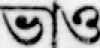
ভাও
